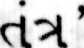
તંત્ર'
